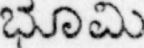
ಭೂಮಿ
